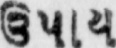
ઉપાય
